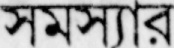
সমস্যার
